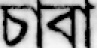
চাবা
